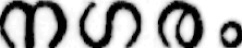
നഗരം
